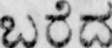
ಬರೆದ
